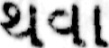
થવા
